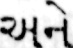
અને
